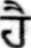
ਹੈ
